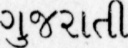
ગુજરાતી
